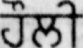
ਹੌਲੀ
